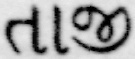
તાજી
